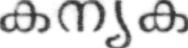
കന്യക
